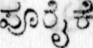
ಪೂರೈಕೆ
